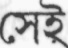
সেই
